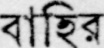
বাহির
